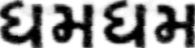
ધમધમ
